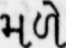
મળે
